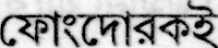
ফোংদোরকই
